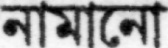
নামানো
